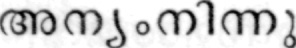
അന്യംനിന്നു
